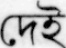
দেই
